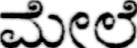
ಮೇಲೆ
